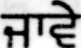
ਜਾਵੇ
